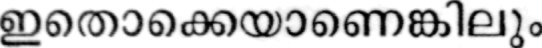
ഇതൊക്കെയാണെങ്കിലും
